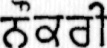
ਨੌਕਰੀ
